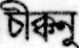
চীক্কনু
